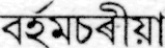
বর্হমচৰীয়া
